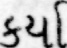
કર્યા
